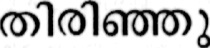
തിരിഞ്ഞു
